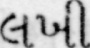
લખી
